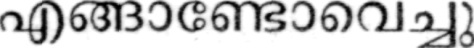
എങ്ങാണ്ടോവെച്ചു
